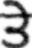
ਤੇ
